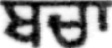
ਬਚਾ
